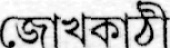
জোখকাঠী
